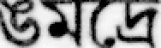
ঙমদ্রে
